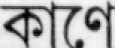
কাণে
